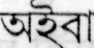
অইবা
